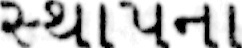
સ્થાપના
